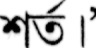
শর্ত।'
